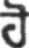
ਹੋ
